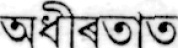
অধীৰতাত
